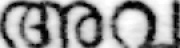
അവ
